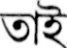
তাই
